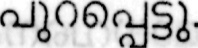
പുറപ്പെട്ടു.
